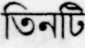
তিনটি
